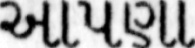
આપણા
